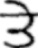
ਤੇ
